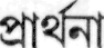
প্রার্থনা
